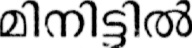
മിനിട്ടില്‍
